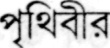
পৃথিবীর
